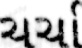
ચર્ચા
